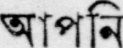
আপনি
